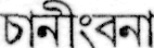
চানীংবনা
